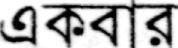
একবার
